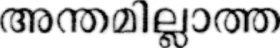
അന്തമില്ലാത്ത
